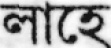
লাহে
